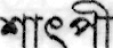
শাৎপী
